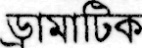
ড্রামাটিক
